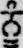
ਨੂੰ
